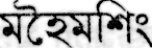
মহৈমশিং
